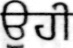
ਉਹੀ
